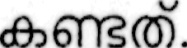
കണ്ടത്.
